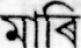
মাৰি
